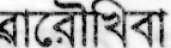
ৱারৌখিবা
